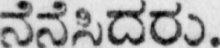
ನೆನೆಸಿದರು.
